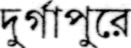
দুর্গাপুরে
